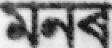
মনৰ
